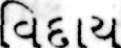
વિદાય
